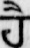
ਹੈ
